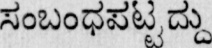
ಸಂಬಂಧಪಟ್ಟದ್ದು
